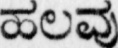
ಹಲವು
